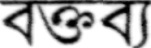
বক্তব্য
